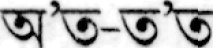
অ'ত-ত'ত
